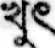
খুৎ
